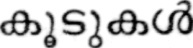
കൂടുകള്‍
